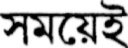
সময়েই
